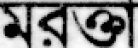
মরক্তা
